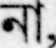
না,
